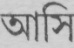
আসি
